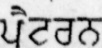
ਪੈਟਰਨ
